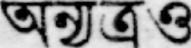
অন্যত্রও
